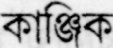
কাঞ্জিক
